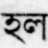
হল
